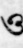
ও
